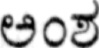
ಅಂಶ
